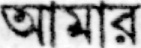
আমার
